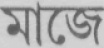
মাজে
